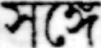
সঙ্গে
